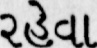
રહેવા
